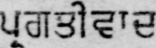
ਪ੍ਰਗਤੀਵਾਦ
